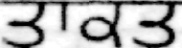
ਤਾਕਤ
